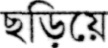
ছড়িয়ে
